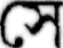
সে
